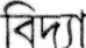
বিদ্যা
